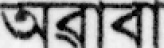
অৱাবা
